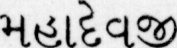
મહાદેવજી
